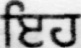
ਇਹ
